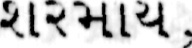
શરમાય,
